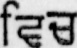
ਵਿਚ
